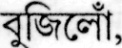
বুজিলোঁ,
